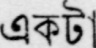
একটা
